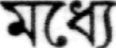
মধ্যে
